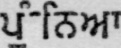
ਪੁੰਨਿਆ
